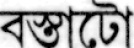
বস্তাটো
